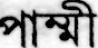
পাম্মী
